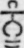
ਨੂੰ
